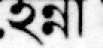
হেন্না
